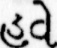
હવે
